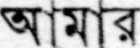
আমার
